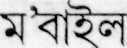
ম'বাইল
